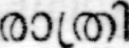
രാത്രി
